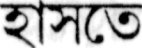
হাসতে
